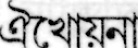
ঐখোয়না
